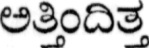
ಅತ್ತಿಂದಿತ್ತ
